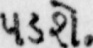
પડશે.
